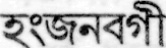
হংজনবগী
